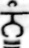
ਨੂੰ
